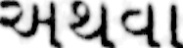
અથવા
